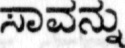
ಸಾವನ್ನು
